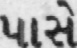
પાસે
